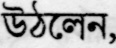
উঠলেন,
